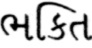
ભક્તિ
